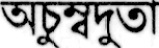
অচুম্বদুতা
